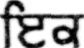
ਇਕ
